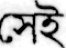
সেই
